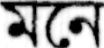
মনে
